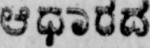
ಆಧಾರದ
